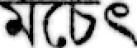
মচেৎ
